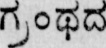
ಗ್ರಂಥದ
